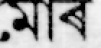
মোৰ
